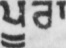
ਪੂਰਾ
